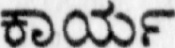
ಕಾರ್ಯ
